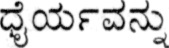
ಧೈರ್ಯವನ್ನು
